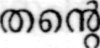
തന്റെ
